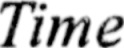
Time
